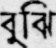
বুঝি
